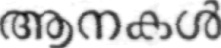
ആനകള്‍
